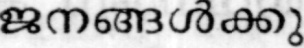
ജനങ്ങള്‍ക്കു
